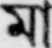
মা
